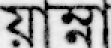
য়াম্না
